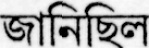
জানিছিল
